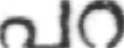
പറ
